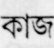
কাজ
